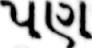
પણ
